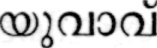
യുവാവ്
